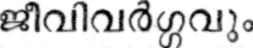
ജീവിവര്‍ഗ്ഗവും
